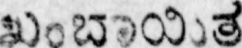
ಖಂಬಾಯಿತ
